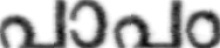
പാപം
